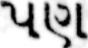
પણ
